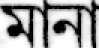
মানা
